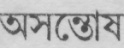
অসন্তোষ
